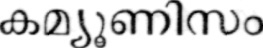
കമ്യൂണിസം
